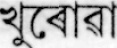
খুৰোৱা
